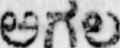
ಅಗಲ
